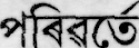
পৰিৱর্তে
